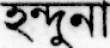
হন্দুনা
